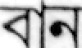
বান
